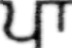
ਪਾ
